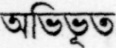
অভিভূত
